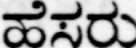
ಹೆಸರು
